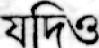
যদিও
